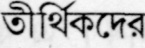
তীর্থিকদের
